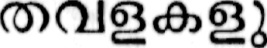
തവളകളു
